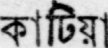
কাটিয়া
